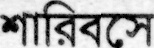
শারিবসে
